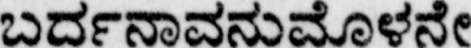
ಬರ್ದನಾವನುಮೊಳನೇ
